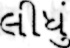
લીધું
